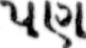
પણ
